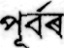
পূর্বৰ
